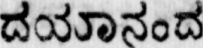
ದಯಾನಂದ
